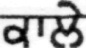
ਕਾਲੇ
